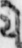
યે
